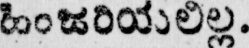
ಹಿಂಜರಿಯಲಿಲ್ಲ.
